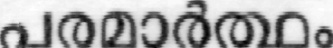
പരമാര്‍ത്ഥം
